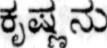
ಕೃಷ್ಣನು
